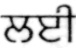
ਲਈ
